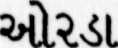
ઓરડા
